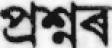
প্ৰশ্নৰ
